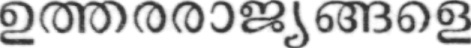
ഉത്തരരാജ്യങ്ങളെ
